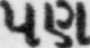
પણ
